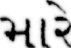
મારે
